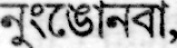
নংঙোনবা,
